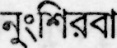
নুংশিরবা
